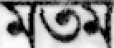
মতম
